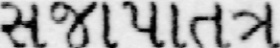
સજાપાતત્ર
